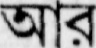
আর
